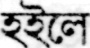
হইলে
